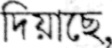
দিয়াছে,
